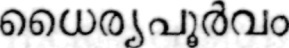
ധൈര്യപൂര്‍വം
